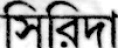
সিরিদা
